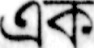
এক
